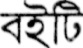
বইটি
